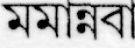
মমান্নবা
